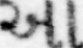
આ
